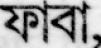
ফাবা,
